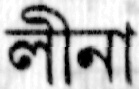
লীনা
